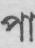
পা
